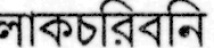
লাকচরিবনি
